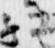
કરે
